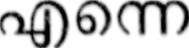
എന്നെ
